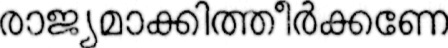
രാജ്യമാക്കിത്തീര്‍ക്കണേ
